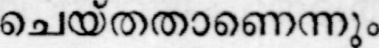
ചെയ്തതാണെന്നും
